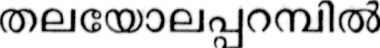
തലയോലപ്പറമ്പില്‍
